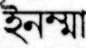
ইনম্মা
